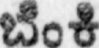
ಬೆಂಕಿ
